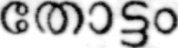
തോട്ടം
